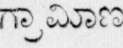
ಗ್ರಾಮೀಣ
